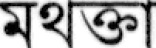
মথক্তা
